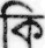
কি
